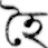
হৈ
